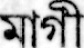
মাগী
